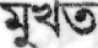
মুখত
